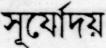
সূর্যোদয়
